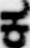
ಕ
